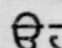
ਉਹ
